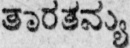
ತಾರತಮ್ಯ
